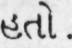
હતો.
